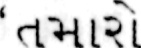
'તમારો
